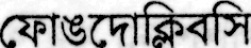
ফোঙদোক্লিবসি
